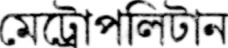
মেট্রোপলিটান
